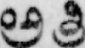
ಅತಿ
